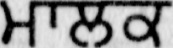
ਮਾਲਕ
